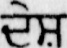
ਦੇਸ਼
